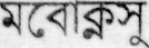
মবোক্নসু
